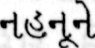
નહનૂને
